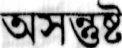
অসন্তুষ্ট
